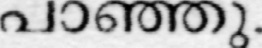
പാഞ്ഞു.
